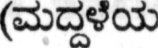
(ಮದ್ದಳೆಯ
